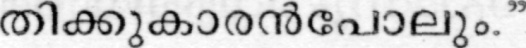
തിക്കുകാരന്‍പോലും.''”
